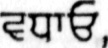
ਵਧਾਓ,
